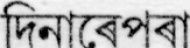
দিনাৰেপৰা
